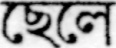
ছেলে
